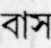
বাস
